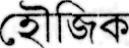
হৌজিক
